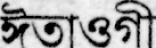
ঈতাওগী
